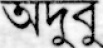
অদুবু
